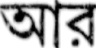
আর
